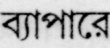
ব্যাপারে
